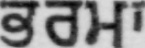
ਭਰਮਾ
